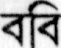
ববি
